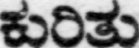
ಕುರಿತು
